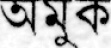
অমুক
